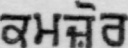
ਕਮਜ਼ੋਰ
